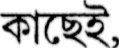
কাছেই,
